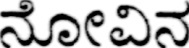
ನೋವಿನ
